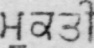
ਮੁਕਤੀ
